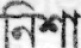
নিশা
